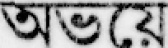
অভয়ে
